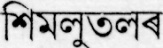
শিমলুতলৰ
